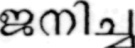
ജനിച്ച
